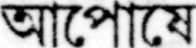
আপোষে
